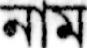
নাম
